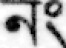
নং
